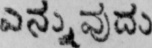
ಎನ್ನುವುದು
